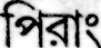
পিরাং
